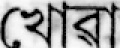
খোৱা
